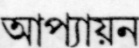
আপ্যায়ন
